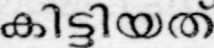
കിട്ടിയത്
